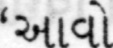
'આવો
